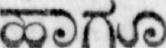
ಹಾಗೂ
